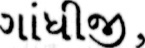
ગાંધીજી,
